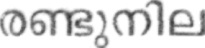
രണ്ടുനില
